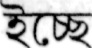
ইচ্ছে
